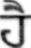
ਹੈ
